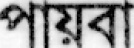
পায়বা
